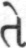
તે
